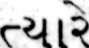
ત્યારે
